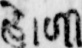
હોળી
